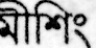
মীশিং
